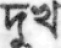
দুখ
